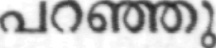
പറഞ്ഞു
